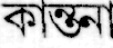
কান্তনা
